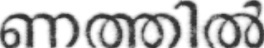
ണത്തില്‍
